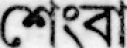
শেংবা
